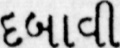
દબાવી
